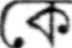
কে
